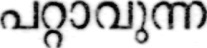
പറ്റാവുന്ന
